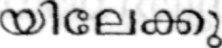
യിലേക്കു
